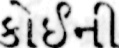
કોઈની
